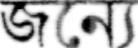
জন্যে
